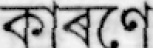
কাৰণে
